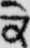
ਕੇ
